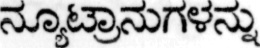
ನ್ಯೂಟ್ರಾನುಗಳನ್ನು
